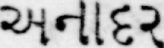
અનાદર
